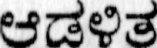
ಆಡಳಿತ
